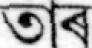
তাৰ
